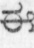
ಈ
